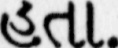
હતા.
